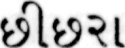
છીછરા
